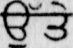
ਉੱਤੇ
